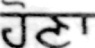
ਹੋਣਾ
